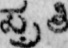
ಪ್ರತಿ
